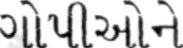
ગોપીઓને
